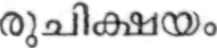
രുചിക്ഷയം
